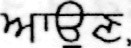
ਆਉਣ,
